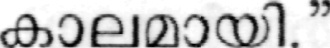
കാലമായി."
